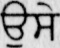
ਉਸੇ
